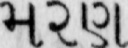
મરણ
